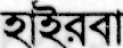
হাইরবা
